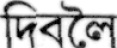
দিবলৈ
